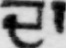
ਦਾ
